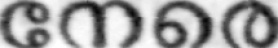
നേരെ
